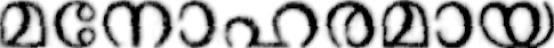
മനോഹരമായ
